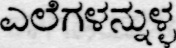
ಎಲೆಗಳನ್ನುಳ್ಳ
